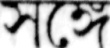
সঙ্গে
